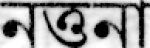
নত্তনা
